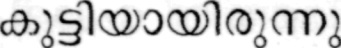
കുട്ടിയായിരുന്നു
